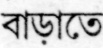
বাড়াতে
